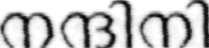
നന്ദിനി
